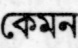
কেমন
